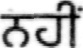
ਨਹੀਂ
